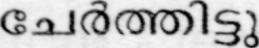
ചേര്‍ത്തിട്ടു
